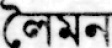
লৈমন
